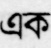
এক
